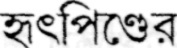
হৃৎপিণ্ডের
